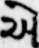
એ
